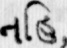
નહિ,
